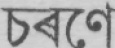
চৰণে
